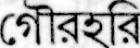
গৌরহরি
